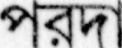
পরদা
